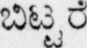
ಬಿಟ್ಟರೆ
